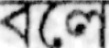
বলে
